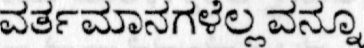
ವರ್ತಮಾನಗಳೆಲ್ಲವನ್ನೂ
